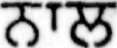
ਨਾਲ
